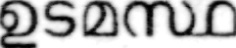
ഉടമസ്ഥ
